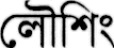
লৌশিং
